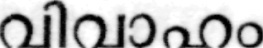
വിവാഹം
